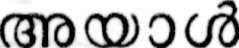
അയാള്‍
